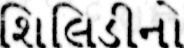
શિલિડીનો
